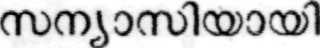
സന്യാസിയായി
